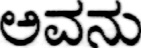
ಅವನು
